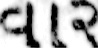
વાર
